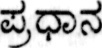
ಪ್ರಧಾನ
